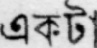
একটা
